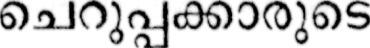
ചെറുപ്പക്കാരുടെ
